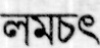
লমচৎ
